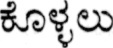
ಕೊಳ್ಳಲು
